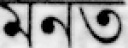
মনত
